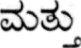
ಮತ್ತು
